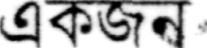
একজন
